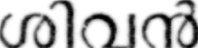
ശിവന്‍
